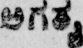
ಅಗತ್ಯ
